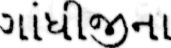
ગાંધીજીના
